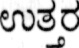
ಉತ್ತರ
